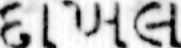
દાખલ
